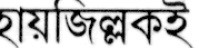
হায়জিল্লকই
